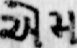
એમ
